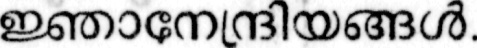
ജ്ഞാനേന്ദ്രിയങ്ങള്‍.
